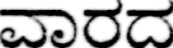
ವಾರದ
